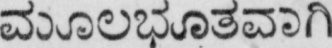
ಮೂಲಭೂತವಾಗಿ
